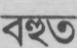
বহুত
